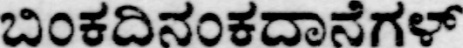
ಬಿಂಕದಿನಂಕದಾನೆಗಳ್
